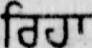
ਰਿਹਾ
